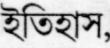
ইতিহাস,
